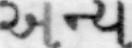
અન્ય
